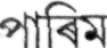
পাৰিম
